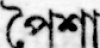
পৈশা
